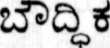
ಬೌದ್ಧಿಕ
